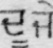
ਦੂਜੇ
